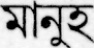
মানুহ
